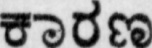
ಕಾರಣ
